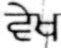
ਵੇਖ
